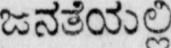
ಜನತೆಯಲ್ಲಿ
